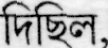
দিছিল,
